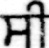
ਸੀ
